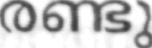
രണ്ടു
